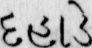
દહાડે
